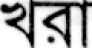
খরা
